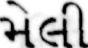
મેલી
